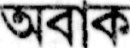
অবাক
